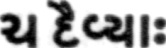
ચદૈવ્યાઃ
